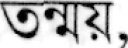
তন্ময়,
